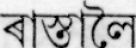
ৰাস্তালৈ
